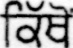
ਕਿੱਥੋਂ
